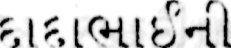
દાદાભાઈની
